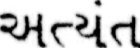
અત્યંત
